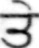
ਤੇ
